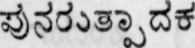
ಪುನರುತ್ಪಾದಕ
